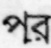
পর
